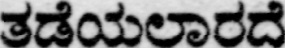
ತಡೆಯಲಾರದೆ
